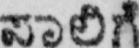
ಪಾಲಿಗೆ
